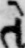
તે
